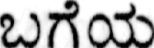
ಬಗೆಯ
